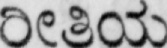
ರೀತಿಯ
